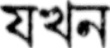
যখন
